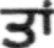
ਤਾਂ
